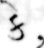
કે,
